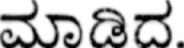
ಮಾಡಿದ.
